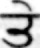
ਤੇ
